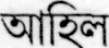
আহিল
